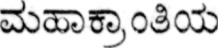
ಮಹಾಕ್ರಾಂತಿಯ
